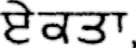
ਏਕਤਾ,
